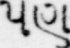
પણ
